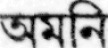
অমনি
